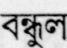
বন্ধুল
